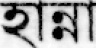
হান্না
